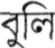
বুলি
